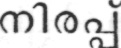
നിരപ്പ്
